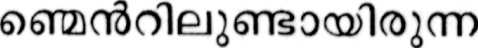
ണ്മെൻറിലുണ്ടായിരുന്ന
